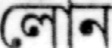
লোন
